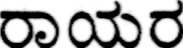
ರಾಯರ
